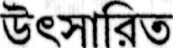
উৎসারিত
